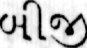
બીજી
